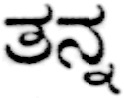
ತನ
